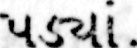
પડ્યાં.
